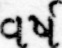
વર્ષ
